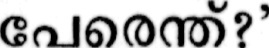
പേരെന്ത്?’
